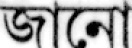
জানো
